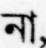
না,
